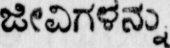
ಜೀವಿಗಳನ್ನು
